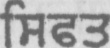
ਸਿਫਤ
